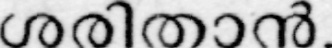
ശരിതാന്‍.
